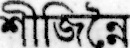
শীজিন্নৈ
